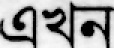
এখন
